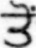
ਤੋਂ
